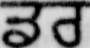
ਡਰ
